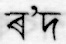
ৰ'দ
